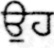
ਉਹ
